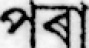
পৰা
